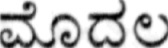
ಮೊದಲ
